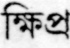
ক্ষিপ্র
